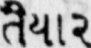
તૈયાર
